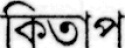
কিতাপ
